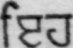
ਇਹ
